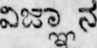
ವಿಜ್ಞಾನ
